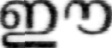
ഈ
